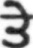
ਤੇ
